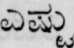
ಎಷ್ಟು
